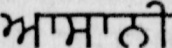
ਆਸਾਨੀ
